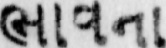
ભાવના
